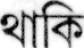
থাকি
